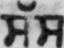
ਸੱਸ
